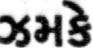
ઝમકે
